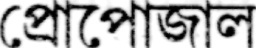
প্রোপোজাল
